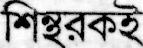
শিন্থরকই
